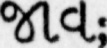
જાવ
